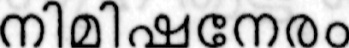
നിമിഷനേരം
